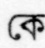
কে
